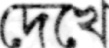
দেখে
